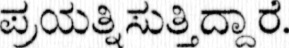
ಪ್ರಯತ್ನಿಸುತ್ತಿದ್ದಾರೆ.
